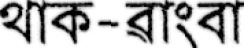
থাক-ৱাংবা
